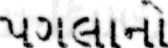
પગલાનો
